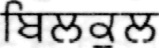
ਬਿਲਕੁਲ
